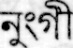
নুংগী
